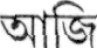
আজি
